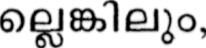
ല്ലെങ്കിലും,
